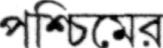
পশ্চিমের
